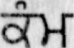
ਕੰਮ
